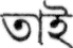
তাই
